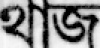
থাজ
